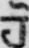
ਹੋ
